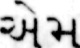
એમ
